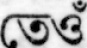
তেওঁ
